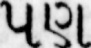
પણ
